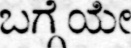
ಬಗ್ಗೆಯೇ
